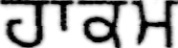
ਹਾਕਮ
